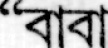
“বাবা
